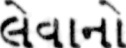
લેવાનો
